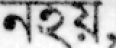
নহয়,
